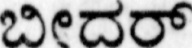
ಬೀದರ್
